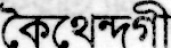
কৈথেন্দগী
